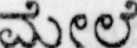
ಮೇಲೆ
